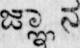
ಜ್ಞಾನ
